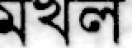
মখল
